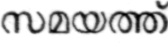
സമയത്ത്
